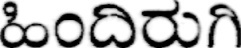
ಹಿಂದಿರುಗಿ
